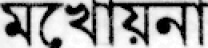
মখোয়না
